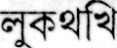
লুকথখি
